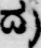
ದ)
